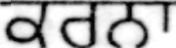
ਕਰਨਾ
